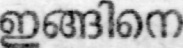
ഇങ്ങിനെ
